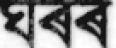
ঘৰৰ
